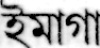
ইমাগা
